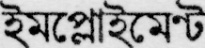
ইমপ্লোইমেণ্ট
